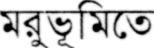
মরুভূমিতে
